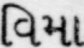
વિમા
